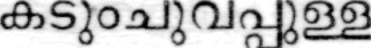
കടുംചുവപ്പുള്ള
